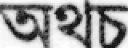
অথচ
